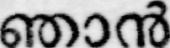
ഞാന്‍
